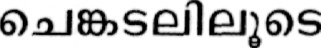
ചെങ്കടലിലൂടെ
